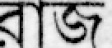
রাজ
